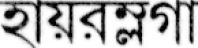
হায়রম্লগা
